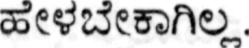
ಹೇಳಬೇಕಾಗಿಲ್ಲ.
